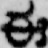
ಈ
